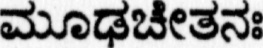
ಮೂಢಚೇತನಃ
